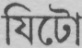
যিটো
